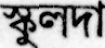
স্কুলদা
